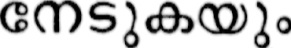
നേടുകയും
